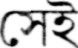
সেই
